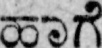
ಹಾಗೆ
